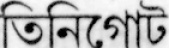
তিনিগোট
